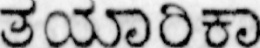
ತಯಾರಿಕಾ
